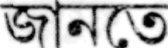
জানতে
